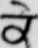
ਕੇ
